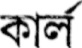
কার্ল
